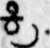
ಕ್ರಿ.
